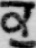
ਕੁ
